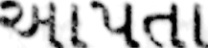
આપતા
